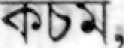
কচম,
